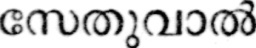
സേതുവാല്‍
